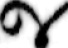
જ
